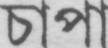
চাপা
